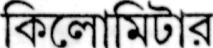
কিলোমিটার
